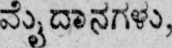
ಮೈದಾನಗಳು,
